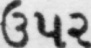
ઉપર
